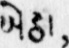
બેઠા,
